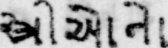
સ્ત્રીઓનો
